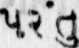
પરંતુ
